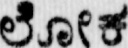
ಲೋಕ
